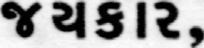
જયકાર,
